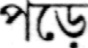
পড়ে
